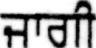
ਜਾਗੀ
